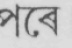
পৰে
